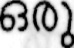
ഒരു
